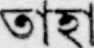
তাহা
